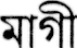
মাগী
